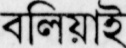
বলিয়াই
